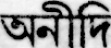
অনীদি
